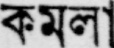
কমলা
